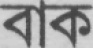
বাক
